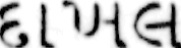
દાખલ
